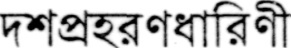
দশপ্রহরণধারিণী
